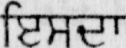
ਇਸਦਾ
